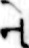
ને
